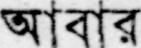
আবার
